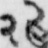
રહે
